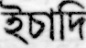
ইচাদি
